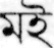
মই
